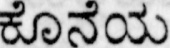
ಕೊನೆಯ
